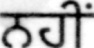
ਨਹੀਂ
